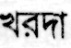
খরদা
